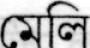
মেলি
